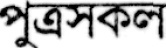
পুত্রসকল
